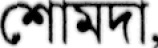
শোমদা,
